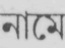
নামে
